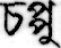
চপ্পু
